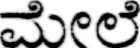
ಮೇಲೆ
